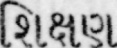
શિક્ષણ
